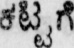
ಕಟ್ಟಿಗೆ
